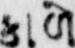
કાળે
